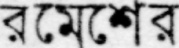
রমেশের
